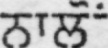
ਨਾਲੋਂ
